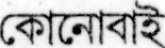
কোনোবাই
